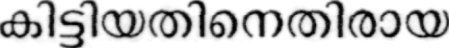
കിട്ടിയതിനെതിരായ
